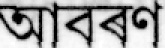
আবৰণ
